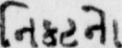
નિકટનો
